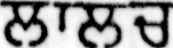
ਲਾਲਚ
